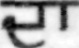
ਦਾ
